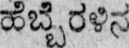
ಹೆಬ್ಬೆರಳಿನ
